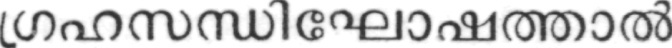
ഗ്രഹസന്ധിഘോഷത്താല്‍
